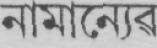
নামান্যেৱ
